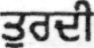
ਤੁਰਦੀ
